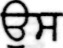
ਉਸ
